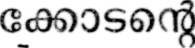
ക്കോടന്റെ
